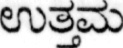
ಉತ್ತಮ
